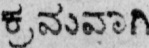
ಕ್ರಮವಾಗಿ
